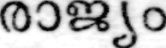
രാജ്യം
